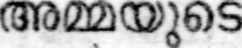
അമ്മയുടെ
